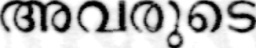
അവരുടെ
